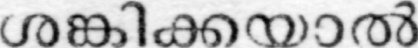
ശങ്കിക്കയാല്‍
